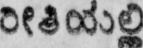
ರೀತಿಯಲ್ಲಿ
